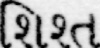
શિશ્ત
